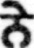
ਨੇ
